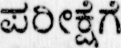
ಪರೀಕ್ಷೆಗೆ
